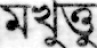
মখুত্তু
